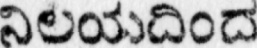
ನಿಲಯದಿಂದ
